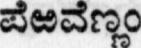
ಪೆಱವೆಣ್ಣಂ
